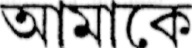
আমাকে
